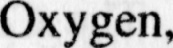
Oxygen,
